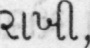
રાખી,
